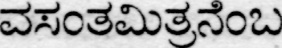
ವಸಂತಮಿತ್ರನೆಂಬ
